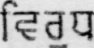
ਵਿਰੁਧ
